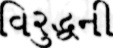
વિરુદ્ધની
